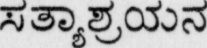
ಸತ್ಯಾಶ್ರಯನ
